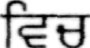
ਵਿਚ
